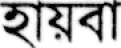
হায়বা
